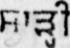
ਸਾੜ੍ਹੀ
